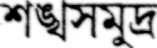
শঙ্খসমুদ্র
